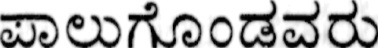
ಪಾಲುಗೊಂಡವರು
